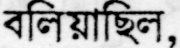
বলিয়াছিল,
